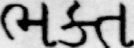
ભક્ત
